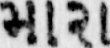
મારા
